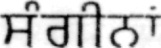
ਸੰਗੀਨਾਂ
